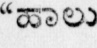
“ಹಾಲು
